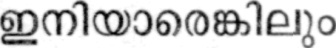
ഇനിയാരെങ്കിലും
